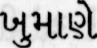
ખુમાણે
